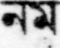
নম
